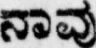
ನಾವು
